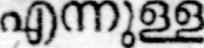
എന്നുള്ള
